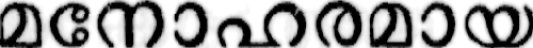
മനോഹരമായ
